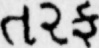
તરફ
